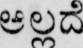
ಅಲ್ಲದೆ
